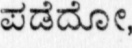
ಪಡೆದೋ,
